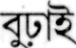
বুঢ়াই
